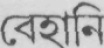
বেহানি
